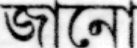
জানো
